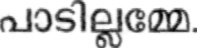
പാടില്ലമ്മേ.
